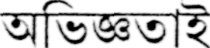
অভিজ্ঞতাই
